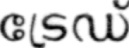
ട്രേഡ്
